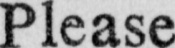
Please
